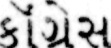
કૉંગ્રેસ
